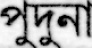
পুদুনা
